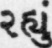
રહ્યું
